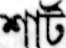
শার্ট
